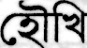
হৌখি
